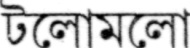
টলোমলো
